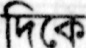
দিকে
